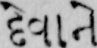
દેવાને
